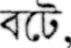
বটে,
